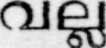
വല്ല
